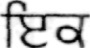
ਇਕ
